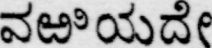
ವಱಿಯದೇ
